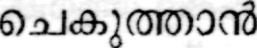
ചെകുത്താന്‍
